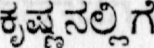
ಕೃಷ್ಣನಲ್ಲಿಗೆ
